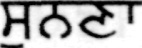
ਸੁਨਣਾ
